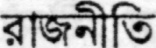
রাজনীতি
